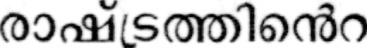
രാഷ്ട്രത്തിന്റെ
